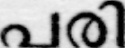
പരി
